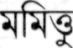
মমিত্তু
